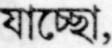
যাচ্ছো,
